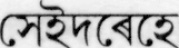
সেইদৰেহে
